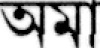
অমা
